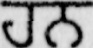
ਹਨ
